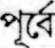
পূর্বে
